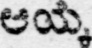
ಆಯ್ಕೆ
